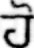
ਹੋ
